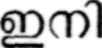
ഇനി
